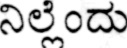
ನಿಲ್ಲೆಂದು
